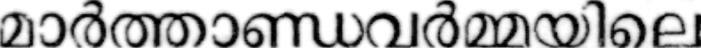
മാര്‍ത്താണ്ഡവര്‍മ്മയിലെ
